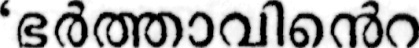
‘ഭര്‍ത്താവിൻെറ
